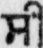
ਸੀ
